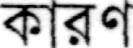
কারণ
